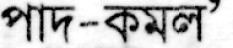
‘পাদ-কমল’
